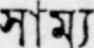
সাম্য
